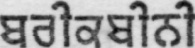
ਬਰੀਕਬੀਨੀ
